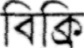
বিক্রি
